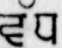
ਵੱਧ
